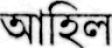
আহিল
